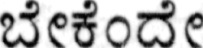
ಬೇಕೆಂದೇ
